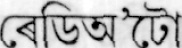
ৰেডিঅ'টো
